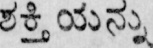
ಶಕ್ತಿಯನ್ನು
